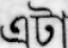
এটা
